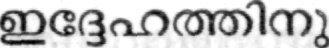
ഇദ്ദേഹത്തിനു
